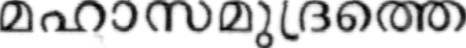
മഹാസമുദ്രത്തെ
